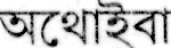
অথোইবা
